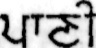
ਪਾਣੀ
